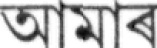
আমাৰ
